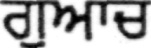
ਗੁਆਚ
